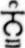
ਨੂੰ
